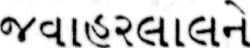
જવાહરલાલને
